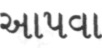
આપવા
